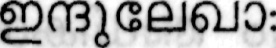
ഇന്ദുലേഖാ:
